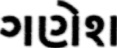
ગણેશ
